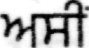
ਅਸੀਂ
